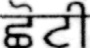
ਛੋਟੀ
